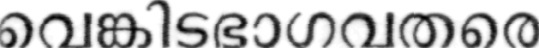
വെങ്കിടഭാഗവതരെ
